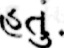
હતું.
